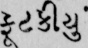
ફુટકીયું
